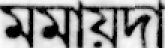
মমায়দো
